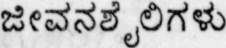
ಜೀವನಶೈಲಿಗಳು
